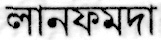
লানফমদা
